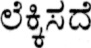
ಲೆಕ್ಕಿಸದೆ
